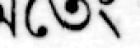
মতেং
